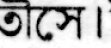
তৌসে
